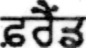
ਫ਼ਰੈਂਡ
